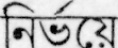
নির্ভয়ে
